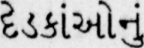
દેડકાંઓનું
